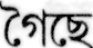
গৈছে
